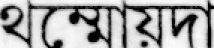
থম্মোয়দা
